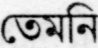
তেমনি
